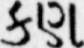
કણ
